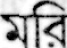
মরি
